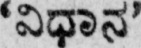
‘ವಿಧಾನ’
